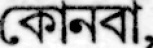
কোনবা,
